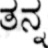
ತನ್ನ
